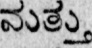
ಮತ್ತು
